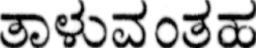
ತಾಳುವಂತಹ
